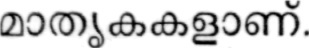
മാതൃകകളാണ്.
